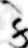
કે
